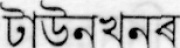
টাউনখনৰ
